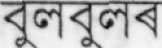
বুলবুলৰ
